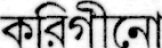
করিগীনো
